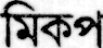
মিকপ
